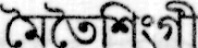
মৈতৈশিংগী
